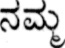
ನಮ್ಮ
